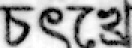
চৎখ্রে
